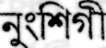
নুংশিগী
